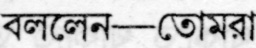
বললেন–তোমরা
